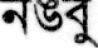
নঙবু
